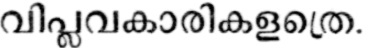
വിപ്ലവകാരികളത്രെ.
